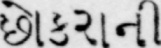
છોકરાની
